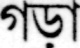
গড়া
